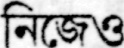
নিজেও
